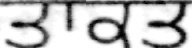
ਤਾਕਤ
